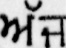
ਅੱਜ
